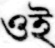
ওই
